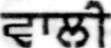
ਵਾਲੀ
